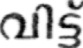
വിട്ട്
